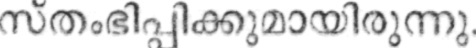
സ്തംഭിപ്പിക്കുമായിരുന്നു.
